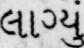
લાગ્યું
